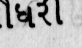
ચૌધરી
